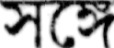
সঙ্গে
